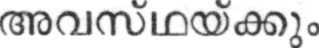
അവസ്ഥയ്ക്കും
